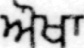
ਔਖਾ
